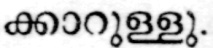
ക്കാറുള്ളു.
